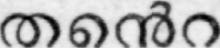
തന്റെ
